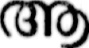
ആ
